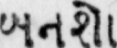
બનશો
